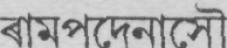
ৰামপদেনাসৌ
